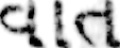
વાત
